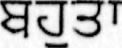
ਬਹੁਤਾ
